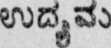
ಉದ್ಯಮ
